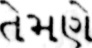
તેમણે
